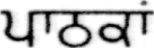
ਪਾਠਕਾਂ
